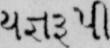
યજ્ઞરૂપી
